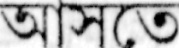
আসতে
